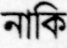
নাকি
